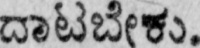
ದಾಟಬೇಕು.
